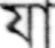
যা
